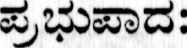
ಪ್ರಭುಪಾದ:
